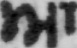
ਆ
